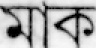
মাক
